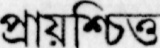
প্রায়শ্চিত্ত
